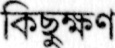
কিছুক্ষণ
